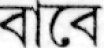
বাবে
